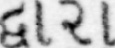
દ્વારા
